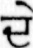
ਦੇ
